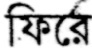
ফিরে
